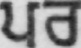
ਪਰ
